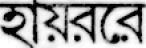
হায়ররে
